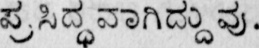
ಪ್ರಸಿದ್ಧವಾಗಿದ್ದುವು.
